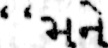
"મને
